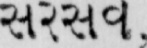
સરસવ,
